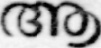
ആ
